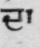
ਦਾ
